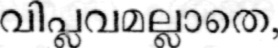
വിപ്ലവമല്ലാതെ,
